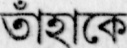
তাঁহাকে
